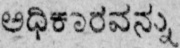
ಅಧಿಕಾರವನ್ನು
